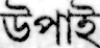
উপাই
